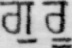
ਗੁਰੂ
